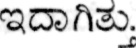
ಇದಾಗಿತ್ತು.
